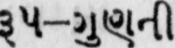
રૂપ-ગુણની
